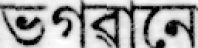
ভগৱানে
